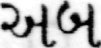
અબ
